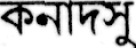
কনাদসু
